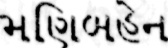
મણિબહેન
